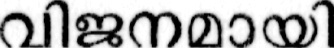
വിജനമായി
